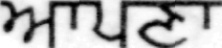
ਆਪਣਾ
